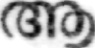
ആ
